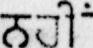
ਨਹੀਂ
